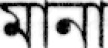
মানা
